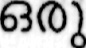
ഒരു
